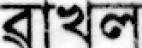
ৱাখল
